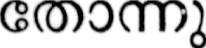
തോന്നു
